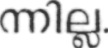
ന്നില്ല.
